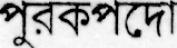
পুরকপদো
